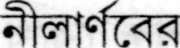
নীলার্ণবের
